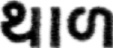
થાળ
